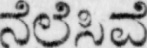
ನೆಲೆಸಿವೆ
